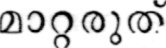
മാറ്റരുത്
